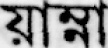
য়াম্না
